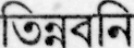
তিন্নবনি
